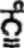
ਨੂੰ
